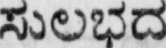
ಸುಲಭದ
